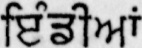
ਇੰਡੀਆਂ
